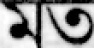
মত
